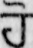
ਹੋ
